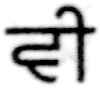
ਵੀ
